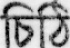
চিঠি
